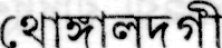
থোঙ্গালদগী
